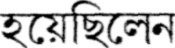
হয়েছিলেন
